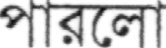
পারলো
